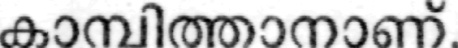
കാമ്പിത്താനാണ്.
